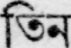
তিন
